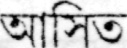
আসিত
